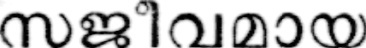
സജീവമായ
